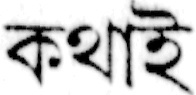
কথাই
